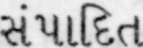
સંપાદિત
